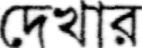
দেখার
